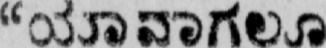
“ಯಾವಾಗಲೂ
